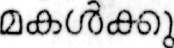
മകള്‍ക്കു
